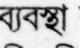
ব্যবস্থা
